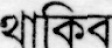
থাকিব
